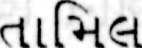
તામિલ
